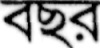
বছর
